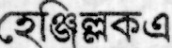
হেঞ্জিল্লকএ
